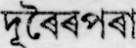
দূৰৈৰপৰা
